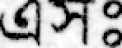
এসঃ
